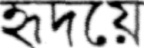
হৃদয়ে
